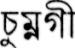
চুম্নগী
